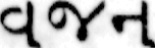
વજન
